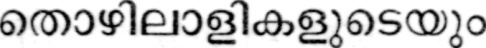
തൊഴിലാളികളുടെയും
